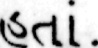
હતાં.
